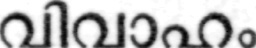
വിവാഹം
